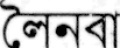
লৈনবা
